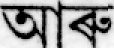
আৰু
